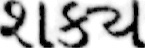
શક્ય
